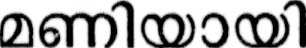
മണിയായി
